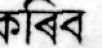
কৰিব
